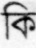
কি
